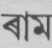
ৰাম
